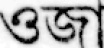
ওজা
